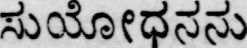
ಸುಯೋಧನನು
